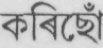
কৰিছোঁ
